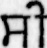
ਸੀ
